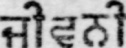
ਜੀਵਨੀ
